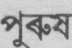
পুৰুষ
